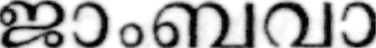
ജാംബവാ
